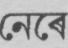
নেৰে
